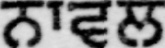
ਨਾਵਲ
